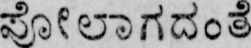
ಪೋಲಾಗದಂತೆ
